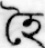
হৈ
